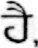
ਹੈ,
